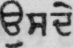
ਉਸਦੇ
